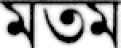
মতম
